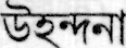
উহন্দনা
